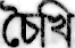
চৈখি
